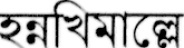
হন্নখিমাল্লে
